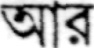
আর
